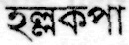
হল্লকপা
